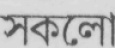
সকলো
